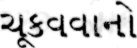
ચૂકવવાનો
